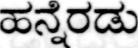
ಹನ್ನೆರಡು
